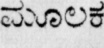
ಮೂಲಕ
